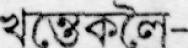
খন্তেকলৈ-
